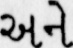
અને
